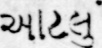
આટલું
